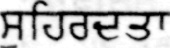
ਸੁਹਿਰਦਤਾ
